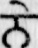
ਨੇ
